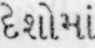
દેશોમાં
